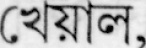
খেয়াল,
